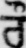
ਰੌ
